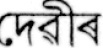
দেৱীৰ
